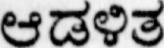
ಆಡಳಿತ
